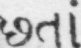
છતાં
